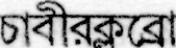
চাবীরক্লব্রো
